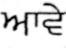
ਆਵੇ
